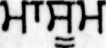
ਮਾਸੂਮ
